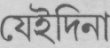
যেইদিনা
